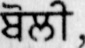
ਬੋਲੀ,
